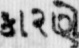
કારણે
